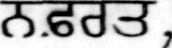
ਨਫ਼ਰਤ,
